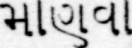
માણવા
